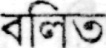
বলিত
